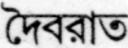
দৈবরাত
